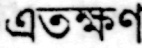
এতক্ষণ
